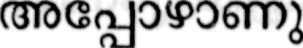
അപ്പോഴാണു
